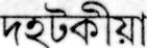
দহটকীয়া
